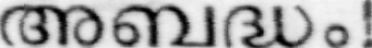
അബദ്ധം!
